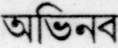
অভিনব
